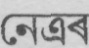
নেত্ৰৰ
